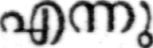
എന്നു
